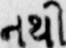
નથી
